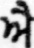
ਐ
